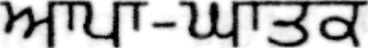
ਆਪਾ-ਘਾਤਕ
